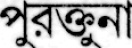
পুরক্তুনা
